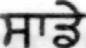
ਸਾਡੇ
